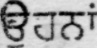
ਉਹਨਾਂ
